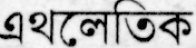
এথলেতিক
